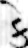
કે
